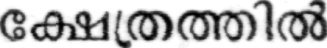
ക്ഷേത്രത്തില്‍
